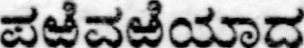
ಪಱೆವಱೆಯಾದ
